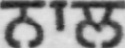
ਨਾਲ
